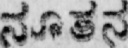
ನೂತನ
